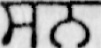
ਸਨ
